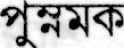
পুম্নমক
